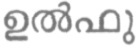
ഉല്‍ഫു
